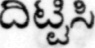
ದಿಟ್ಟಿಸಿ
